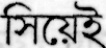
সিয়েই
